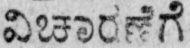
ವಿಚಾರಣೆಗೆ
